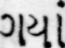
ગયાં
